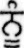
ਨੂੰ
